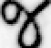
જ
